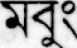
মবুং
